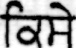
ਕਿਸੇ
